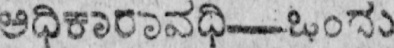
ಅಧಿಕಾರಾವಧಿ-ಒಂದು
